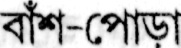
বাঁশ-পোড়া
